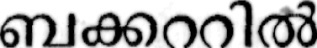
ബക്കററില്‍
